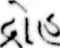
દ્રોહ
